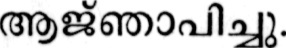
ആജ്ഞാപിച്ചു.
